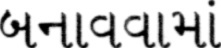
બનાવવામાં
